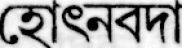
হোৎনবদা
